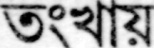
তংখায়
